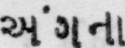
અંગના
